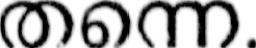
തന്നെ.
